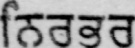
ਨਿਰਭਰ
